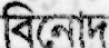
বিনোদ
